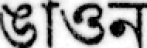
ঙাওন
